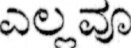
ಎಲ್ಲವೂ
